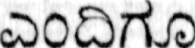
ಎಂದಿಗೂ
